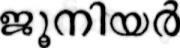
ജൂനിയര്‍
